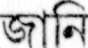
জানি
